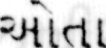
ઓતા
